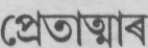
প্ৰেতাত্মাৰ
